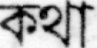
কথা
